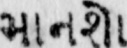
માનશો
